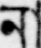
না
